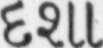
દશા
